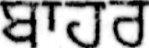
ਬਾਹਰ
